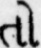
તો
